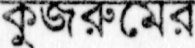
কুজরুমের
